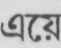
এয়ে
